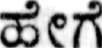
ಹೇಗೆ
